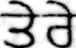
ਤੇਰੇ
